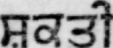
ਸ਼ਕਤੀ
